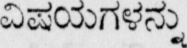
ವಿಷಯಗಳನ್ನು
